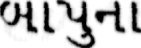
બાપુના
